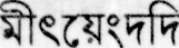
মীৎয়েংদদি
